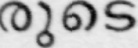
രുടെ
